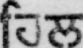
ਹਿਲ
